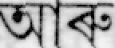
আৰু
